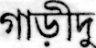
গাড়ীদু
